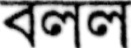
বলল
